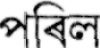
পৰিল
